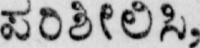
ಪರಿಶೀಲಿಸಿ,
